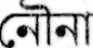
নৌনা
